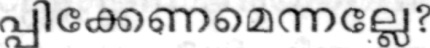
പ്പിക്കേണമെന്നല്ലേ?
